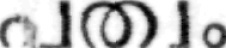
പത്വം
